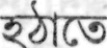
হঠাতে
